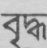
বৃদ্ধ
